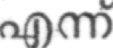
എന്ന്
